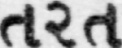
તરત
